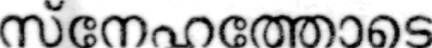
സ്നേഹത്തോടെ
